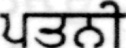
ਪਤਨੀ
